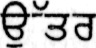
ਉੱਤਰ
